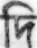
দি
